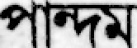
পান্দম
